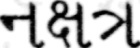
નક્ષત્ર
